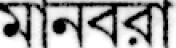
মানবরা
